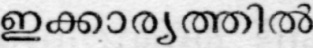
ഇക്കാര്യത്തില്‍
